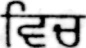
ਵਿਚ
